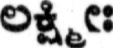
ಲಕ್ಷ್ಮೀಃ
